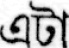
এটা
